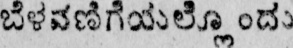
ಬೆಳವಣಿಗೆಯಲ್ಲೊಂದು
